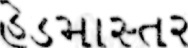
હેડમાસ્તર
